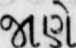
જાણે
